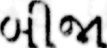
બીજા
